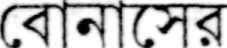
বোনাসের
